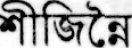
শীজিন্নৈ
